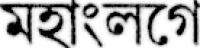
মহাংলগে
